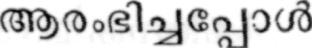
ആരംഭിച്ചപ്പോള്‍
